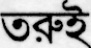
তরুই
